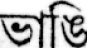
ভাঙি
